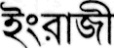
ইংরাজী
